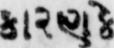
કારણકે
